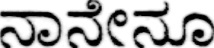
ನಾನೇನೂ
